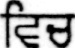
ਵਿਚ
